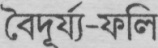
বৈদূৰ্য্য-ফলি
